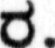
ರ.
